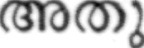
അതു
